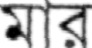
মার
